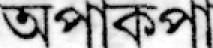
অপাকপা
